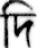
দি
